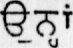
ਉਨ੍ਹਾਂ
